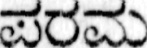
ಪರಮ
